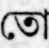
তো
